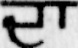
ਦਾ
